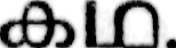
കഥ.
